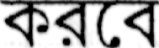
করবে
